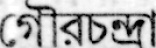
গৌরচন্দ্রা
